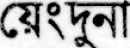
য়েংদুনা
